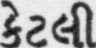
કેટલી
